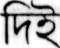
দিই
